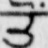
ਤੋਂ
